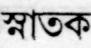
স্নাতক
